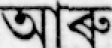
আৰু
